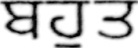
ਬਹੁਤ
